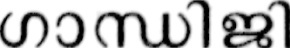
ഗാന്ധിജി
